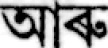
আৰু
